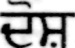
ਦੋਸ਼
